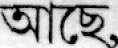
আছে,
